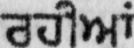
ਰਹੀਆਂ
